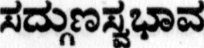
ಸದ್ಗುಣಸ್ವಭಾವ
